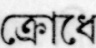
ক্রোধে
